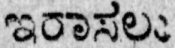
ಇರಾಸಲು
